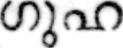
ഗുഹ
